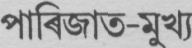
পাৰিজাত-মুখ্য
